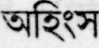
অহিংস
